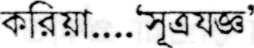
করিয়া....‘সূত্রযজ্ঞ’
